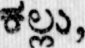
ಕಲ್ಲು,
